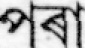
পৰা
